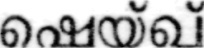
ഷെയ്ഖ്
